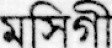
মসিগী
